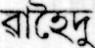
ৱাহৈদু
